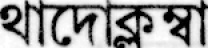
থাদোক্লম্বা
